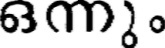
ഒന്നും
